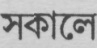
সকালে
